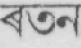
ৰতন
